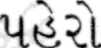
પહેરો
